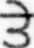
ਤੇ
